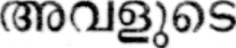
അവളുടെ
